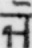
ਜੋ
